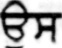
ਉਸ
